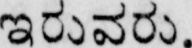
ಇರುವರು.
